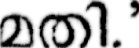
മതി.’
